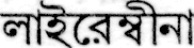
লাইরেম্বীনা
